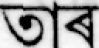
তাৰ
